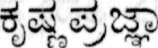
ಕೃಷ್ಣಪ್ರಜ್ಞಾ
